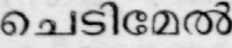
ചെടിമേല്‍
